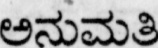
ಅನುಮತಿ
